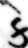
કે
